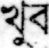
খুব
